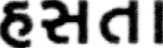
હસતા
